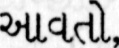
આવતો,
